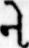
ને
